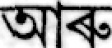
আৰু
